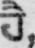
ਹੈ,
